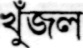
খুঁজল
